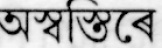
অস্বস্তিৰে
